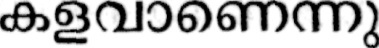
കളവാണെന്നു
